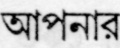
আপনার
